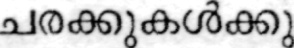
ചരക്കുകള്‍ക്കു
